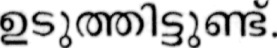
ഉടുത്തിട്ടുണ്ട്.
